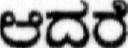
ಆದರೆ
